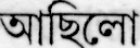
আছিলো
